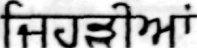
ਜਿਹੜੀਆਂ
